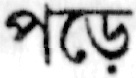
পড়ে
